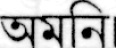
অমনি।
